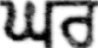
ਘਰ
